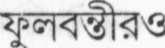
ফুলবন্তীরও
